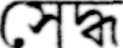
সেদ্ধ
